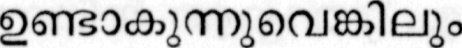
ഉണ്ടാകുന്നുവെങ്കിലും
